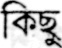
কিছু
